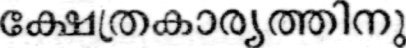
ക്ഷേത്രകാര്യത്തിനു
